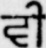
ਵੀ
